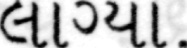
લાગ્યા.
